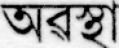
অৱস্হা
